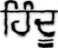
ਹਿੰਦੂ
